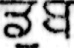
ਡੁਬ
